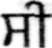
ਸੀ
